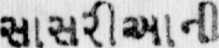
સાસરીઆની
